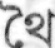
থৈ
